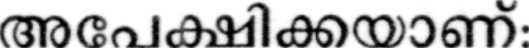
അപേക്ഷിക്കയാണ്:
